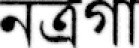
নত্রগা
